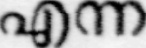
എന്ന
